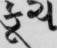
કૂચ
